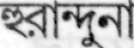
হুরান্দুনা
